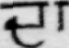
ਦਾ
